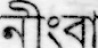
নীংবা
